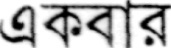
একবার
